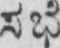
ಸಭೆ
